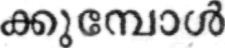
ക്കുമ്പോള്‍
